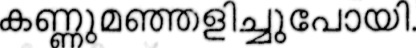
കണ്ണുമഞ്ഞളിച്ചുപോയി.
